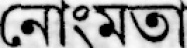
নোংমতা
